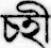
চহী
